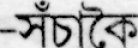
-সঁচাকৈ
